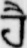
ਹੈ
